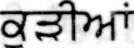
ਕੁੜੀਆਂ
